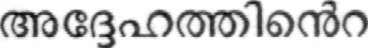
അദ്ദേഹത്തിന്റെ
